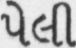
પેલી
